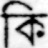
কি
